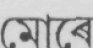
মোৰে
